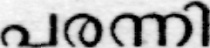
പരന്നി
